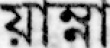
য়াম্না
